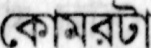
কোমরটা
